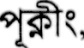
পূক্নীং,
